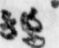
કહું
